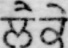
ਲੈਕੇ
